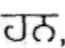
ਹਨ,
